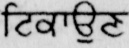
ਟਿਕਾਉਣ
